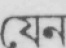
যেন
